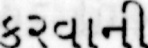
કરવાની
